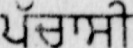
ਪੱਚਾਸੀ
